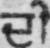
ਦੀ
